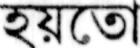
হয়তো
